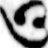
ও
